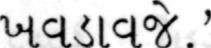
ખવડાવજે.'
